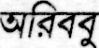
অরিববু
